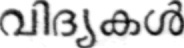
വിദ്യകള്‍
